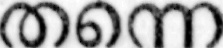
തന്നെ
